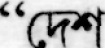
"দেশ
